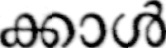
ക്കാള്‍
